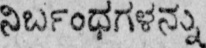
ನಿರ್ಬಂಧಗಳನ್ನು
